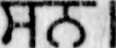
ਸਨ।
